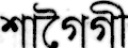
শাগৈগী
